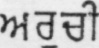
ਅਰੁਚੀ
